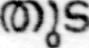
തുട
